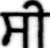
ਸੀ
